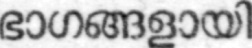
ഭാഗങ്ങളായി
